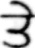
ਤੇ
